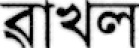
ৱাখল
